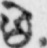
છે.
